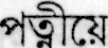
পত্নীয়ে
